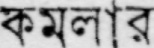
কমলার
